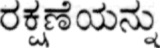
ರಕ್ಷಣೆಯನ್ನು
